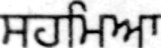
ਸਹਮਿਆ
